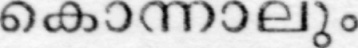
കൊന്നാലും
